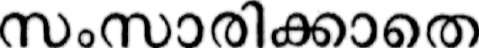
സംസാരിക്കാതെ
